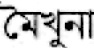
মৈখুনা
